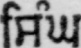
ਸਿੰਘ
